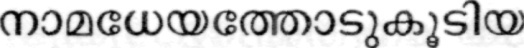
നാമധേയത്തോടുകൂടിയ
